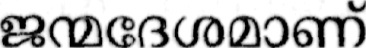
ജന്മദേശമാണ്
